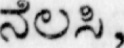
ನೆಲಸಿ,
